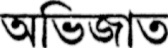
অভিজাত
